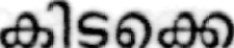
കിടക്കെ
